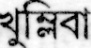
খুম্লিবা
